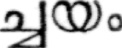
ച്ചയം
